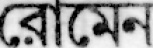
রোমেন
